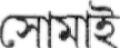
সোমাই
